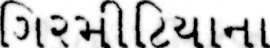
ગિરમીટિયાના
